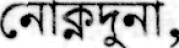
নোক্নদুনা,
